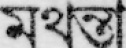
মথন্তা
